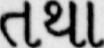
તથા
